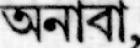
অনাবা,
